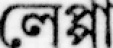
লেপ্পা
